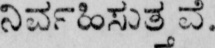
ನಿರ್ವಹಿಸುತ್ತವೆ.
